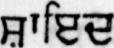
ਸ਼ਾਇਦ
